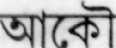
আকৌ
